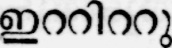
ഇററിററു
